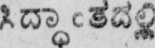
ಸಿದ್ಧಾ೦ತದಲ್ಲಿ
